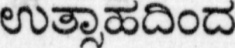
ಉತ್ಸಾಹದಿಂದ
